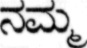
ನಮ್ಮ
